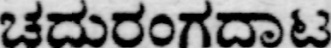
ಚದುರಂಗದಾಟ
